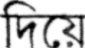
দিয়ে
